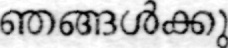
ഞങ്ങള്‍ക്കു
